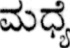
ಮಧ್ಯೆ
